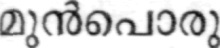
മുന്‍പൊരു
